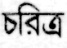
চরিত্র
